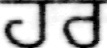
ਹਰ
